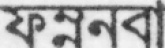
ফম্ননবা
